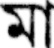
মা
